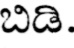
ಬಿಡಿ.
